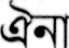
ঐনা
